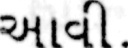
આવી.
